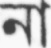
না
